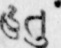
હતું
